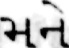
મને
